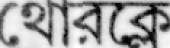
থোরক্লে
